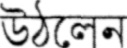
উঠলেন
